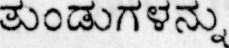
ತುಂಡುಗಳನ್ನು
